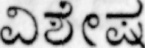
ವಿಶೇಷ
